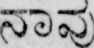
ನಾವು
